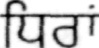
ਧਿਰਾਂ
